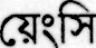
য়েংসি
